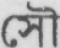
সৌ
